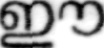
ഈ
